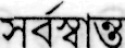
সর্বস্বান্ত
